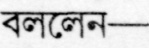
বললেন–
